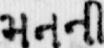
મનની
